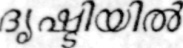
ദൃഷ്ടിയില്‍
